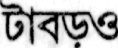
টাবড়ও
